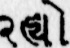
રહ્યો
